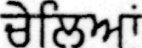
ਚੇਲਿਆਂ
